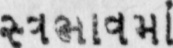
સ્વભાવમાં
